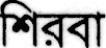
শিরবা
